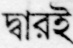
দ্বারই
